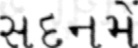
સદનમેં
